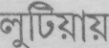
লুটিয়ায়
